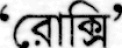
‘রোক্সি’
